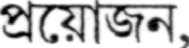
প্রয়োজন,
